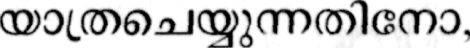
യാത്രചെയ്യുന്നതിനോ,
